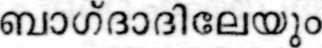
ബാഗ്ദാദിലേയും
